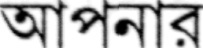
আপনার
